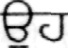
ਉਹ
